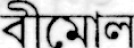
বীমোল
